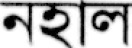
নহাল
